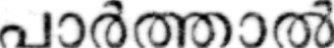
പാര്‍ത്താല്‍
